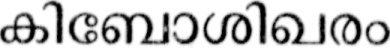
കിബോശിഖരം
